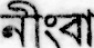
নীংবা
